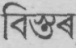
বিস্তৰ
